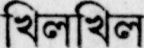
খিলখিল
